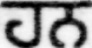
ਹਨ
